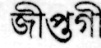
জীপ্তগী
